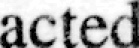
acted
